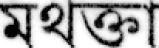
মথক্তা
